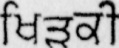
ਖਿੜਕੀ
